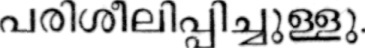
പരിശീലിപ്പിച്ചുള്ളു.
